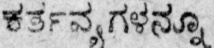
ಕರ್ತವ್ಯಗಳನ್ನೂ
